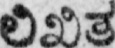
ಲಿಖಿತ
